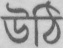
উঠি
